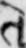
તે
